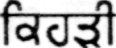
ਕਿਹੜੀ
